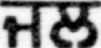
ਜਲ
